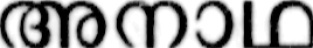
അനാഥ
